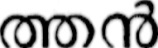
ത്തന്‍
